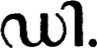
ഡി.
